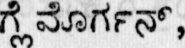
ಗ್ಲೆಮೊರ್ಗನ್,
